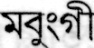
মবুংগী
